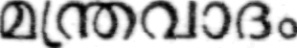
മന്ത്രവാദം
